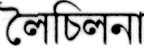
লৈচিলনা
